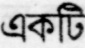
একটি
